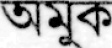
অমুক
